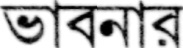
ভাবনার
